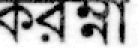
করম্না
